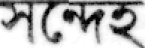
সন্দেহ
